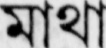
মাথা
